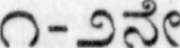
೧-೨ನೇ
